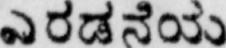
ಎರಡನೆಯ
